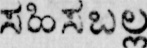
ಸಹಿಸಬಲ್ಲ
